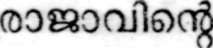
രാജാവിന്റെ
